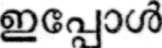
ഇപ്പോള്‍
